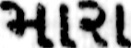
મારા
